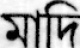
মাদি
